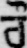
ਰੌ
